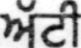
ਅੱਟੀ
